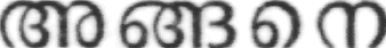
അങ്ങനെ
